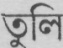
তুলি
